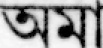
অমা
